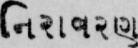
નિરાવરણ
